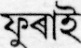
ফুৰাই
